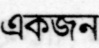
একজন
